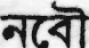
নবৌ
